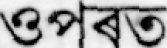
ওপৰত
